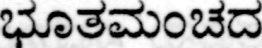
ಭೂತಮಂಚದ
